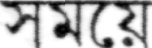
সময়ে
